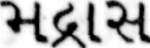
મદ્રાસ
